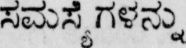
ಸಮಸ್ಯೆಗಳನ್ನು
